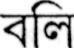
বলি
